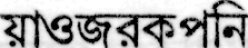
য়াওজরকপনি
